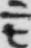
ਦੇ
